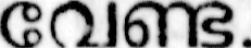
വേണ്ട.
